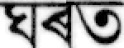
ঘৰত
